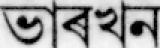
ভাৰখন
